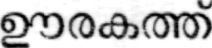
ഊരകത്ത്
